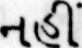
નહીં
